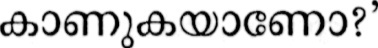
കാണുകയാണോ?’
